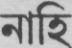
নাহি
